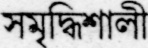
সমৃদ্ধিশালী
